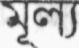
মূল্য
